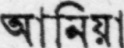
আনিয়া
